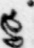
હું
